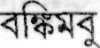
বঙ্কিমবু
